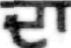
ਦਾ
